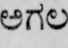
ಅಗಲ
